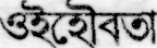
ওইহৌবতা
